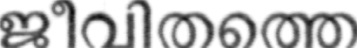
ജീവിതത്തെ
